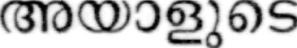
അയാളുടെ
